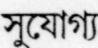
সুযোগ্য
